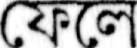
ফেলে
